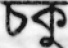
চকু
